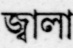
জ্বালা
